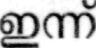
ഇന്ന്
